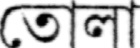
তোলা
